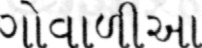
ગોવાળીઆ
